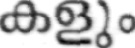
കളും
